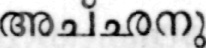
അച്ഛനു
